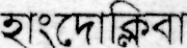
হাংদোক্লিবা
